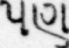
પણ
